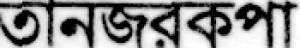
তানজরকপা
